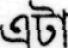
এটা
